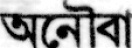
অনৌবা
